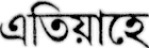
এতিয়াহে
